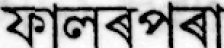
ফালৰপৰা
